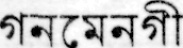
গনমেনগী
